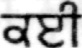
ਕਈ
